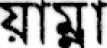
য়াম্না
